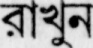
রাখুন
